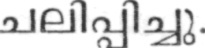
ചലിപ്പിച്ചു.
